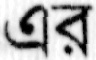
এর
